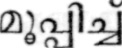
മൂപ്പിച്ച്
